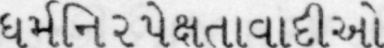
ધર્મનિરપેક્ષતાવાદીઓ
